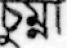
চুম্না
